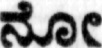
ನೋ
